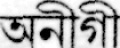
অনীগী
